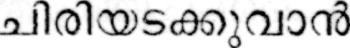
ചിരിയടക്കുവാന്‍
